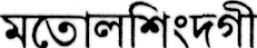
মতোলশিংদগী
